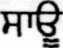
ਸਾਊ
